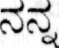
ನನ್ನ
